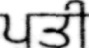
ਪਤੀ
